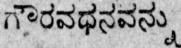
ಗೌರವಧನವನ್ನು
